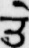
ਤੇ
